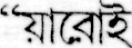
“য়ারোই
